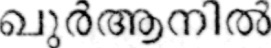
ഖുര്‍ആനില്‍
